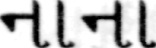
નાના
